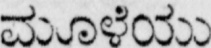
ಮೂಳೆಯು
